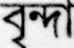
বৃন্দা
